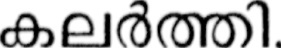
കലര്‍ത്തി.
